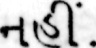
નહીં.
